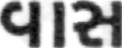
વાસ
